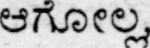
ಆಗೋಲ್ಲ,
